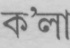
ক'লা
